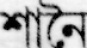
শানৈ
